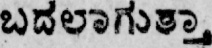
ಬದಲಾಗುತ್ತಾ
